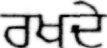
ਰਖਦੇ
